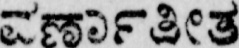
ವರ್ಣಾತೀತ
